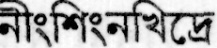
নীংশিংনখিদ্রে
